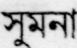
সুমনা
